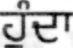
ਹੁੰਦਾ
